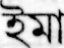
ইমা
